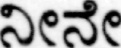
ನೀನೇ
